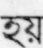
হয়
